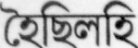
হৈছিলহি
